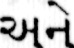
અને
